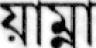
য়াম্না
